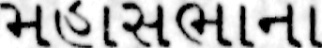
મહાસભાના
